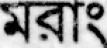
মরাং
